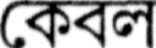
কেবল
